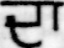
ਦਾ
